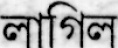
লাগিল
